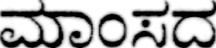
ಮಾಂಸದ
